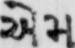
એમ
